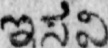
ಇಸವಿ
